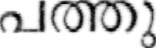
പത്തു
